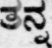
ತನ್ನ
